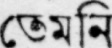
তেমনি
